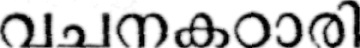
വചനകഠാരി
